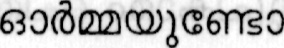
ഓര്‍മ്മയുണ്ടോ
